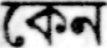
কেন
